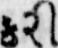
કરી
